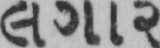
લગાર
